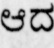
ಆದ
